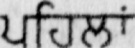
ਪਹਿਲਾਂ
